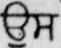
ਉਸ
